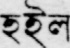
হইল
